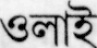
ওলাই
